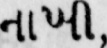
નાખી,
